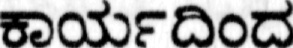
ಕಾರ್ಯದಿಂದ
